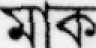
মাক
